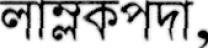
লাম্লকপদা,
